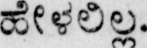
ಹೇಳಲಿಲ್ಲ.
